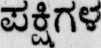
ಪಕ್ಷಿಗಳ
